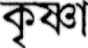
কৃষ্ণা
